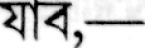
যাব,-
